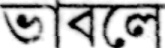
ভাবলে
